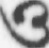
ও
